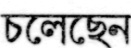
চলেছেন
